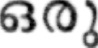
ഒരു
